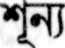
শূন্য
